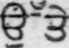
ਉੱਤੇ
